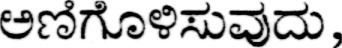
ಅಣಿಗೊಳಿಸುವುದು,
